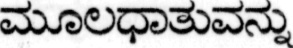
ಮೂಲಧಾತುವನ್ನು
